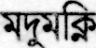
মদুমক্তি
